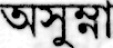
অসুম্না
